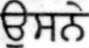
ਉਸਨੇ
